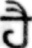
ਹੈ
